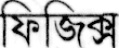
ফিজিক্স
